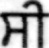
ਸੀ
